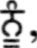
ਨੂੰ,
